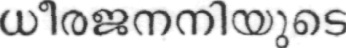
ധീരജനനിയുടെ
